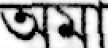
অমা
